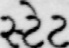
સ્ટેટ
